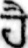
ਹੈ
